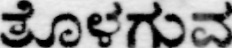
ತೊಳಗುವ
